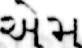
એમ
